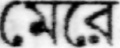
মেরে
